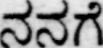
ನನಗೆ
